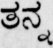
ತನ್ನ
